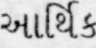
આર્થિક
